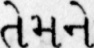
તેમને
